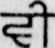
ਵੀ
